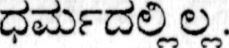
ಧರ್ಮದಲ್ಲಿಲ್ಲ.
